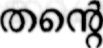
തന്റെ
